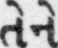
તેને
